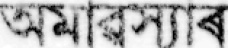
অমাৱস্যাৰ
